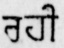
ਰਹੀ
